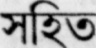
সহিত
